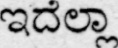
ಇದೆಲ್ಲಾ
